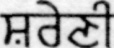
ਸ਼ਰੇਣੀ
